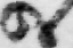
જ
